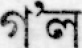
গ'ল
